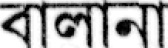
বালানা
